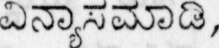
ವಿನ್ಯಾಸಮಾಡಿ,
